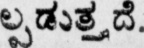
ಲ್ಪಡುತ್ತದೆ.
